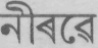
নীৰৱে
